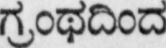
ಗ್ರಂಥದಿಂದ
